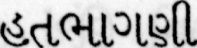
હતભાગણી
